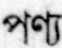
পণ্য
